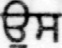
ਉਸ
